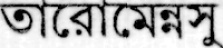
তারোমেন্নসু
